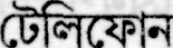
টেলিফোন
